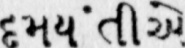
દમયંતીએ
